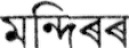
মন্দিৰৰ
